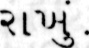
રાખું.
